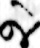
જે
